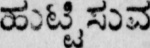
ಹುಟ್ಟಿಸುವ
